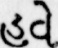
હવે
